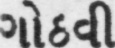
ગોઠવી
